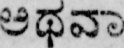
ಅಥವಾ
